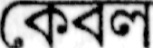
কেবল
